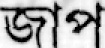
জাপ
